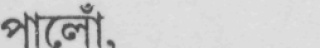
পালোঁ,
